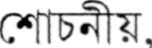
শোচনীয়,
